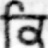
ਕਿ
